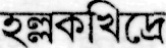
হল্লকখিদ্রে
